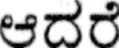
ಆದರೆ
